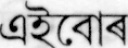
এইবোৰ
